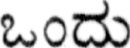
ಒಂದು
